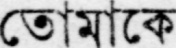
তোমাকে
